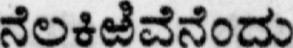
ನೆಲಕಿಱವೆನೆಂದು
